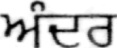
ਅੰਦਰ
